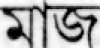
মাজ
